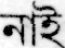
নাই
